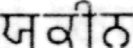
ਯਕੀਨ
